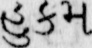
હુકમ
